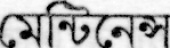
মেন্টিনেন্স
